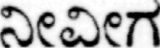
ನೀವೀಗ
